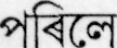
পৰিলে
